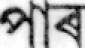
পাৰ
